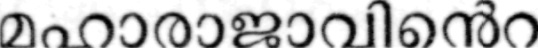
മഹാരാജാവിന്റെ
